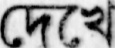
দেখে
